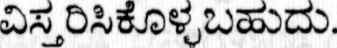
ವಿಸ್ತರಿಸಿಕೊಳ್ಳಬಹುದು.
